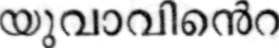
യുവാവിന്റെ
